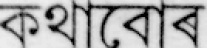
কথাবোৰ
